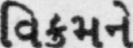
વિક્રમને
